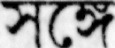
সঙ্গে
